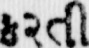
કરતી
